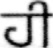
ਹੀ
